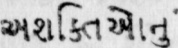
અશક્તિઓનું
